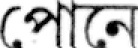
পোনে
